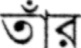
তাঁর
